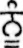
ਨੂੰ
